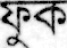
ফুক
